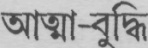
আত্মা-বুদ্ধি
